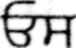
ਓਸ
